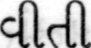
વીતી
